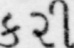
કરી
